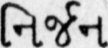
નિર્જન
